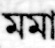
মমা
